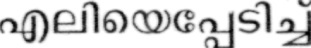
എലിയെപ്പേടിച്ച്
